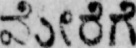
ಮೇರೆಗೆ
